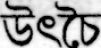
উৎচৈ
